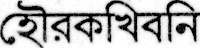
হৌরকখিবনি
